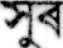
সুৰ
